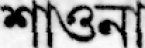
শাওনা
